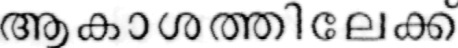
ആകാശത്തിലേക്ക്
